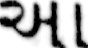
આ
